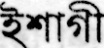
ইশাগী
